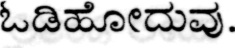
ಓಡಿಹೋದುವು.
